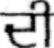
ਦੀ
